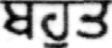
ਬਹੁਤ
